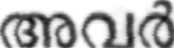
അവര്‍
